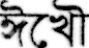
ঈখৌ
